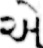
એ
